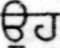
ਉਹ
